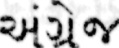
અંગ્રેજ
